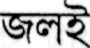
জলই
